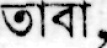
তাবা,
